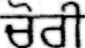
ਚੋਰੀ
